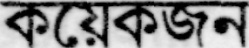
কয়েকজন
